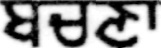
ਬਚਣਾ
